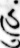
હું
